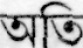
অতি
